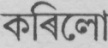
কৰিলো
